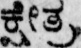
ಕ್ಷೇತ್ರ
